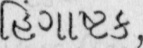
હિંગાષ્ટક,
